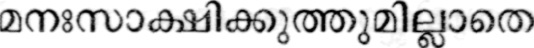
മനഃസാക്ഷിക്കുത്തുമില്ലാതെ
